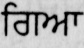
ਗਿਆ
